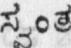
ಸ್ವಂತ
